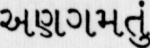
અણગમતું
